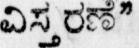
ವಿಸ್ತರಣೆ”
